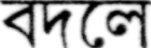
বদলে
